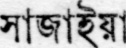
সাজাইয়া
